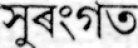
সুৰংগত
